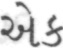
એક
